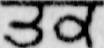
ਤਕ
